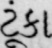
ટૂંકા
